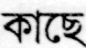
কাছে
